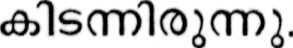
കിടന്നിരുന്നു.
